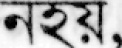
নহয়,
